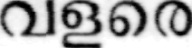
വളരെ
